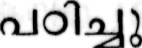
പഠിച്ചു
